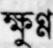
ক্ষুণ্ণ
